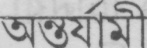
অন্তর্যামী
